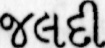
જલદી
